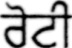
ਰੋਟੀ
